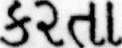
કરતા
